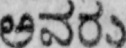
ಅವರು
